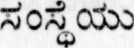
ಸಂಸ್ಥೆಯು
